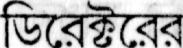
ডিরেক্টরের
